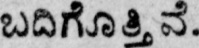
ಬದಿಗೊತ್ತಿವೆ.
